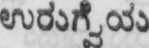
ಉರುಗ್ವೆಯ
